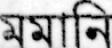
মমানি
